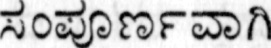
ಸಂಪೂರ್ಣವಾಗಿ
